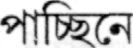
পাচ্ছিনে
